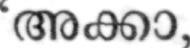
'അക്കാ,
